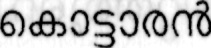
കൊട്ടാരന്‍
